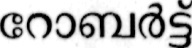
റോബര്‍ട്ട്
